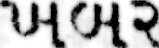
ખબર
